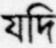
যদি
